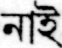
নাই
